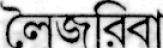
লৈজরিবা
